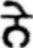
ਨੇ
